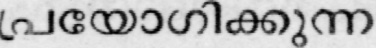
പ്രയോഗിക്കുന്ന
